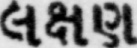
લક્ષણ
